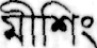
মীশিং
